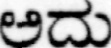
ಅದು
